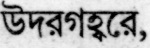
উদরগহ্বরে,
